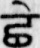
ਛੇ
